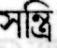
সন্ত্রি
